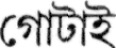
গোটাই
